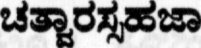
ಚತ್ವಾರಸ್ಸಹಜಾ
